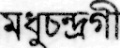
মধুচন্দ্রগী
